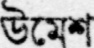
উমেশ
